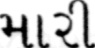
મારી
